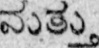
ಮತ್ತು
